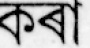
কৰা
